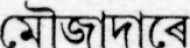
মৌজাদাৰে
